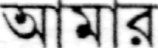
আমার
